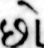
છો
